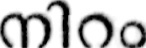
നിറം
